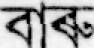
বাৰু
